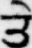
ਤੇ
